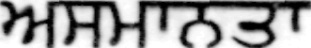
ਅਸਮਾਨਤਾ
